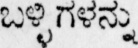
ಬಳ್ಳಿಗಳನ್ನು
